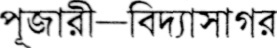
পূজারী–বিদ্যাসাগর
